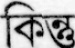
কিন্তু
